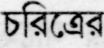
চরিত্রের
